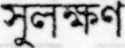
সুলক্ষণ
